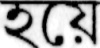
হয়ে
